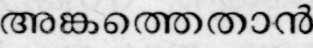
അങ്കത്തെതാന്‍
